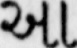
આ
